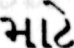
માટે
